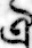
ঐ
